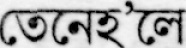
তেনেহ'লে
